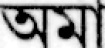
মচা
